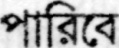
পারিবে
